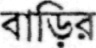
বাড়ির
